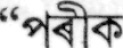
"পৰীক
